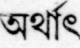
অর্থাত্
